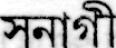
সনাগী
